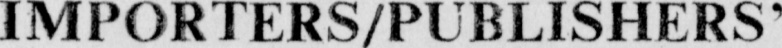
IMPORTERS/PUBLISHERS’
